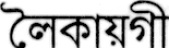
লৈকায়গী
